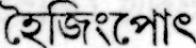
হৈজিংপোৎ
